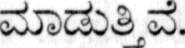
ಮಾಡುತ್ತಿವೆ.
